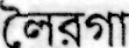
লৈরগা
